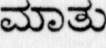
ಮಾತು
